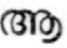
ആ
